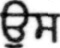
ਉਸ
